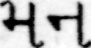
મન
